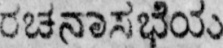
ರಚನಾಸಭೆಯ
